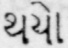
થયો
